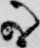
જે
